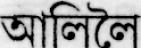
আলিলৈ
